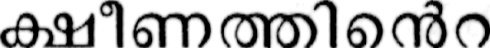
ക്ഷീണത്തിന്റെ
